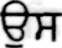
ਉਸ
